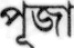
পূজা
